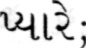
પ્યારે;
